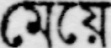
মেয়ে
